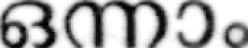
ഒന്നാം
